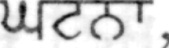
ਘਟਨਾ,
